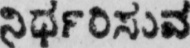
ನಿರ್ಧರಿಸುವ
